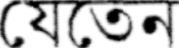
যেতেন
